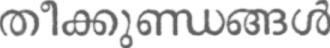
തീക്കുണ്ഡങ്ങള്‍
